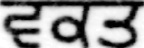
ਵਕਤ
